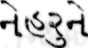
નેહરુને
